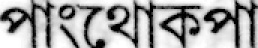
পাংথোকপা
